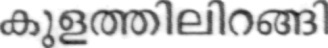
കുളത്തിലിറങ്ങി
